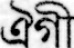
ঐগী
